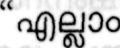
''എല്ലാം
